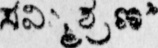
ಸಮ್ಮಿಶ್ರಣ”
